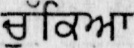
ਚੁੱਕਿਆ
